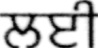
ਲਈ
